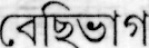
বেছিভাগ
